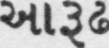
આરૂઢ
